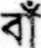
বাঁ
